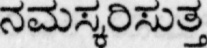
ನಮಸ್ಕರಿಸುತ್ತ
